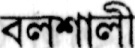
বলশালী
